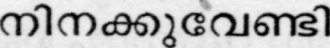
നിനക്കുവേണ്ടി
